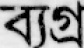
ব্যগ্ৰ
